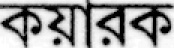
কয়ারক
